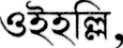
ওইহল্লি,
